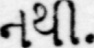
નથી.
